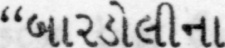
“બારડોલીના
